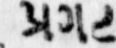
પ્રગટ
